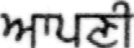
ਆਪਣੀ
